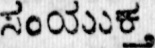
ಸಂಯುಕ್ತ
